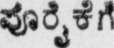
ಪೂರೈಕೆಗೆ
